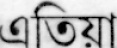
এতিয়া
